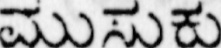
ಮುಸುಕು
